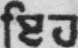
ਇਹ
